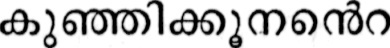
കുഞ്ഞിക്കൂനന്റെ
